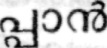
പ്പാന്‍
